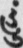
હું
